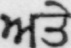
ਅਤੇ
